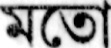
মতো
